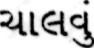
ચાલવું
